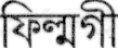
ফিল্মগী
